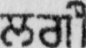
ਲਗੀ
